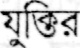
যুক্তির
